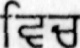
ਵਿਚ
